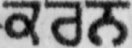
ਕਰਨ
